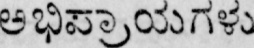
ಅಭಿಪ್ರಾಯಗಳು
